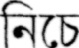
নিচে
